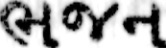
ભજન
